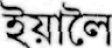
ইয়ালৈ
